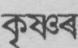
কৃষ্ণৰ
